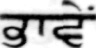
ਭਾਵੇਂ
